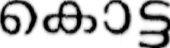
കൊട്ട
